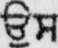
ਉਸ
